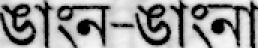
ঙাংন-ঙাংনা
